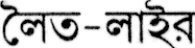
লৈত-লাইর
